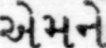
એમને
